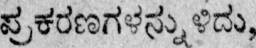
ಪ್ರಕರಣಗಳನ್ನುಳಿದು,
